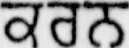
ਕਰਨ
